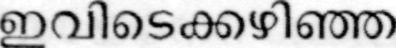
ഇവിടെക്കഴിഞ്ഞ
